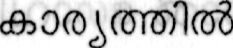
കാര്യത്തില്‍
